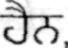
ਹੈਨ,
